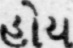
હોય
